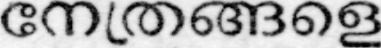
നേത്രങ്ങളെ
